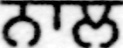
ਨਾਲ
